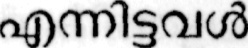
എന്നിട്ടവള്‍
